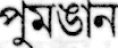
পুমঙান
